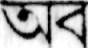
অব
